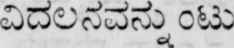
ವಿದಲನವನ್ನುಂಟು
